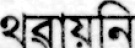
থৱায়নি
